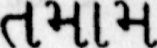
તમામ
